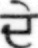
ਦੇ
